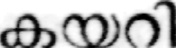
കയറി
